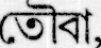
তৌবা,
